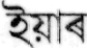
ইয়াৰ
